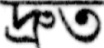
দ্রুত
